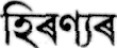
হিৰণ্যৰ
